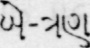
બે-ત્રણ
